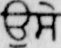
ਉਸੇ
